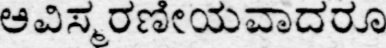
ಅವಿಸ್ಮರಣೀಯವಾದರೂ
